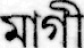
মাগী
